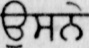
ਉਸਨੇ
